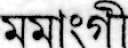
মমাংগী
